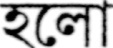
হলো
